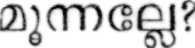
മൂന്നല്ലേ?
